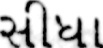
સીધા
